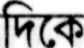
দিকে
